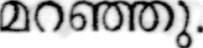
മറഞ്ഞു.
